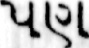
પણ
